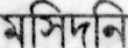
মসিদনি
